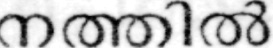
നത്തില്‍
